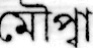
মৌপ্বা
